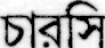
চারসি
